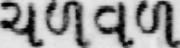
ચળવળ
